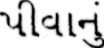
પીવાનું
